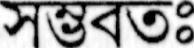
সম্ভবতঃ
